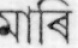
মাৰি
